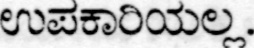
ಉಪಕಾರಿಯಲ್ಲ.
